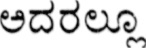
ಅದರಲ್ಲೂ
